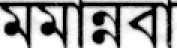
মমান্নবা
